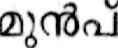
മുന്‍പ്
